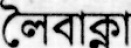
লৈবাক্না
